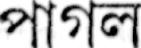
পাগল
